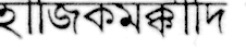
হৌজিকমক্কীদি
